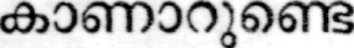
കാണാറുണ്ടെ
